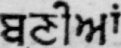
ਬਣੀਆਂ
